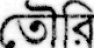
তৌরি
